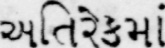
અતિરેકમાં
